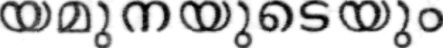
യമുനയുടെയും
